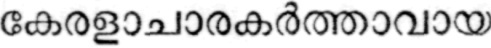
കേരളാചാരകര്‍ത്താവായ
